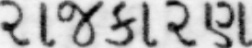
રાજકારણ
